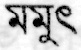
মমুৎ
